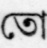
তো
